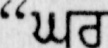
''ਘਰ
